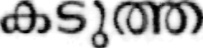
കടുത്ത
